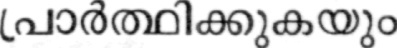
പ്രാര്‍ത്ഥിക്കുകയും
